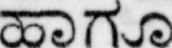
ಹಾಗೂ
